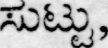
ಸುಟ್ಟು,
